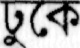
ঢুকে
